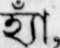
হ্যাঁ,
